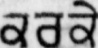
ਕਰਕੇ
